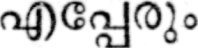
എപ്പേരും
